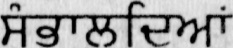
ਸੰਭਾਲਦਿਆਂ
